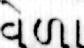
વેળા
